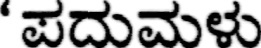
'ಪದುಮಳು
